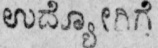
ಉದ್ಯೋಗಿಗೆ
